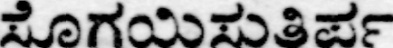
ಸೊಗಯಿಸುತಿರ್ಪ
